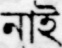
নাই
